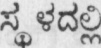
ಸ್ಥಳದಲ್ಲಿ
